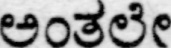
ಅ೦ತಲೇ
